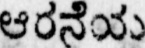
ಆರನೆಯ
